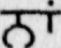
ਨਾਂ
